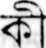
কী
